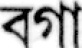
বগা
